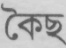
কৈছ
